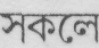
সকলে
